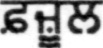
ਫ਼ਜ਼ੂਲ
